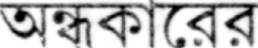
অন্ধকারের
